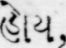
હોય,
